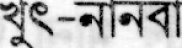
খুৎ-নানবা
